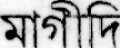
মাগীদি
